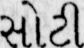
સોટી
